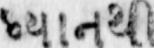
ધ્યાનથી
